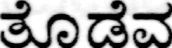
ತೊಡೆವ
